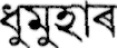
ধুমুহাৰ
